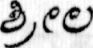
ಶ್ರೀಲ
